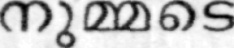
നുമ്മടെ
